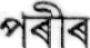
পৰীৰ
